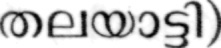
തലയാട്ടി)
